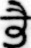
ਭੈ
